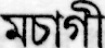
মচাগী
